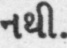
નથી.
